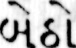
બેઠો
